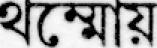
থম্মোয়
